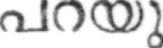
പറയു
